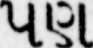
પણ
